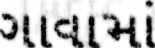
ગાવામાં
